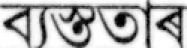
ব্যস্ততাৰ
